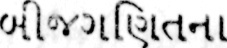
બીજગણિતના
